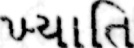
ખ્યાતિ
